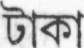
টাকা
